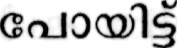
പോയിട്ട്
